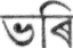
ভৰি
